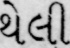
થેલી
